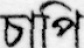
চাপি
